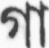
গা
